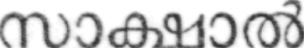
സാക്ഷാല്‍
